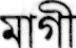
মাগী
